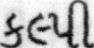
કલ્પી
